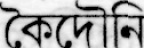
কৈদৌনি
